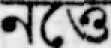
নত্তে
